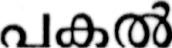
പകല്‍
